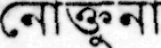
নোক্তুনা
